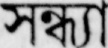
সন্ধ্যা
